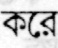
করে
